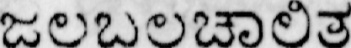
ಜಲಬಲಚಾಲಿತ
